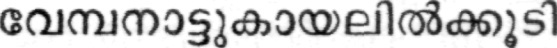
വേമ്പനാട്ടുകായലില്‍ക്കൂടി
